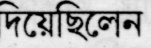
দিয়েছিলেন
